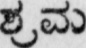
ಶ್ರಮ
